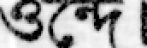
ওন্দে।
